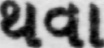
થવા
